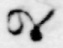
જ
